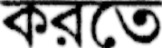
করতে
